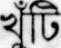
খুঁটি
